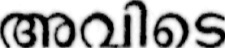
അവിടെ
